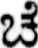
ಚೆ
